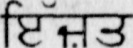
ਇੱਜ਼ਤ
